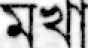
মখা
